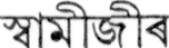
স্বামীজীৰ
